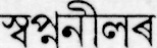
স্বপ্ননীলৰ
